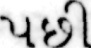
પછી
